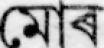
মোৰ
